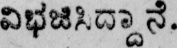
ವಿಭಜಿಸಿದ್ದಾನೆ.
